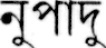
নুপাদু
